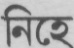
নিহে
